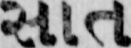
સાત
